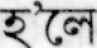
হ'লে
